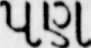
પણ
